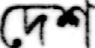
দেশ
